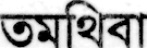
তমথিবা
